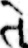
તે
